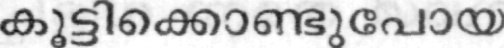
കൂട്ടിക്കൊണ്ടുപോയ
